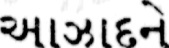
આઝાદને
